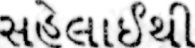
સહેલાઈથી
